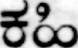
ಕಹಿ
